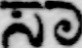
ಸಾ
